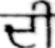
ਦੀ
